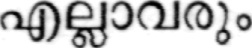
എല്ലാവരും
